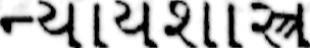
ન્યાયશાસ્ત્ર
